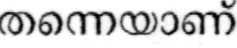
തന്നെയാണ്
